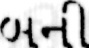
બની
